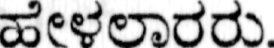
ಹೇಳಲಾರರು.
